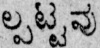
ಲ್ಪಟ್ಟವು
